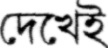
দেখেই
